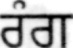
ਰੰਗ
